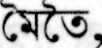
মৈতৈ,
